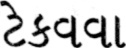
ટેકવવા
